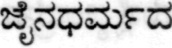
ಜೈನಧರ್ಮದ
